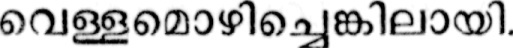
വെള്ളമൊഴിച്ചെങ്കിലായി.
